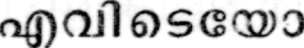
എവിടെയോ
